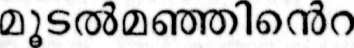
മൂടല്‍മഞ്ഞിന്റെ
